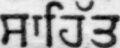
ਸਾਹਿੱਤ
